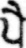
ਪੈ
